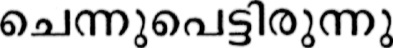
ചെന്നുപെട്ടിരുന്നു
